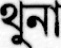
থুনা
